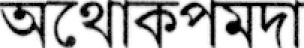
অথোকপমদা
